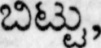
ಬಿಟ್ಟು,
